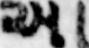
આ
